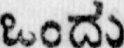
ಒಂದು
